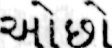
ઓછો
